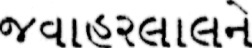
જવાહરલાલને
